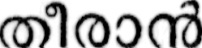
തീരാന്‍
